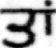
ਤਾਂ
